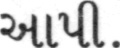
આપી.
